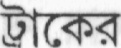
ট্রাকের
